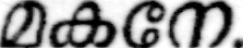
മകനേ.
